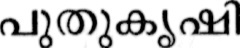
പുതുകൃഷി
